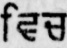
ਵਿਚ
